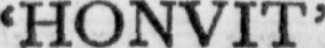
‘HONVIT’
